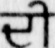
ਦੀ
